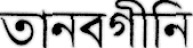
তানবগীনি
